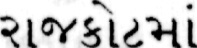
રાજકોટમાં
